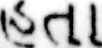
હતા
